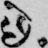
છે.
